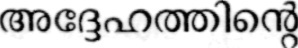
അദ്ദേഹത്തിന്റെ
